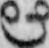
ಆ
